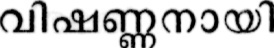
വിഷണ്ണനായി
